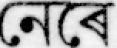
নেৰে
